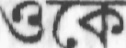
ওকে
